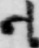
ન
